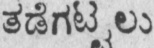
ತಡೆಗಟ್ಟಲು
